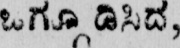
ಒಗ್ಗೂಡಿಸಿದ,
